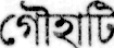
গৌহাটি
